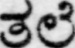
ತಲೆ
